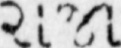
રાજા
